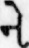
ને
